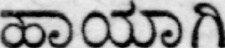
ಹಾಯಾಗಿ
